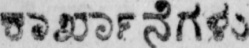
ಕಾರ್ಖಾನೆಗಳು
